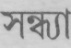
সন্ধা
